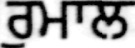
ਰੁਮਾਲ
